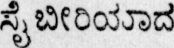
ಸೈಬೀರಿಯಾದ
